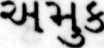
અમુક
